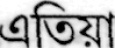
এতিয়া
